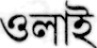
ওলাই
